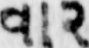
વાર
